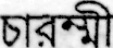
চারম্মী
